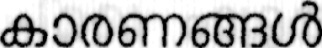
കാരണങ്ങള്‍
